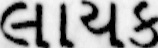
લાયક
